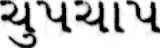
ચુપચાપ
